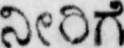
ನೀರಿಗೆ
